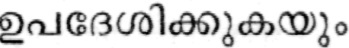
ഉപദേശിക്കുകയും
